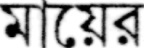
মায়ের
